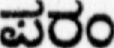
ಪರ೦
